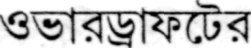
ওভারড্রাফটের
